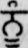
ਨੂੰ
